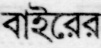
বাইরের
